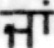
ਜਾਂ
